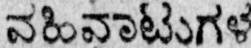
ವಹಿವಾಟುಗಳ
